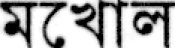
মখোল
